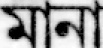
মানা
